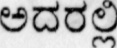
ಅದರಲ್ಲಿ
